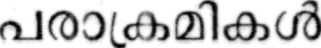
പരാക്രമികള്‍
